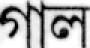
গাল
